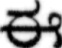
ಈ
